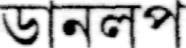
ডানলপ
